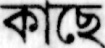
কাছে
